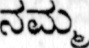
ನಮ್ಮ
